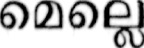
മെല്ലെ
